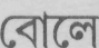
বোলে
